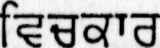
ਵਿਚਕਾਰ
